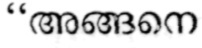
"അങ്ങനെ
